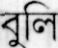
বুলি
